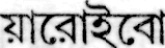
যারোইবো
